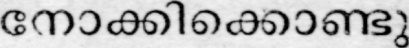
നോക്കിക്കൊണ്ടു
